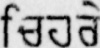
ਚਿਹਰੇ
